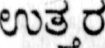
ಉತ್ತರ
